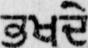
ਭਖਦੇ
